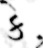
કે,
